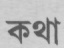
কথা
